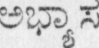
ಅಭ್ಯಾಸ
